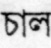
চাল
